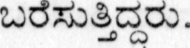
ಬರೆಸುತ್ತಿದ್ದರು.
